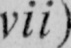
vii)
